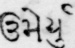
ઉમેર્યું
